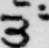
ਤੋਂ
